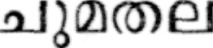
ചുമതല
